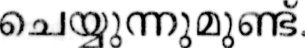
ചെയ്യുന്നുമുണ്ട്.
